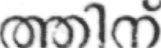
ത്തിന്
